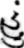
હું
